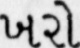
ખરો
